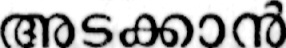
അടക്കാന്‍
